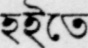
হইতে
